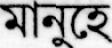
মানুহে
